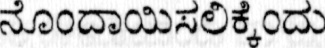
ನೊಂದಾಯಿಸಲಿಕ್ಕೆಂದು
